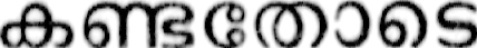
കണ്ടതോടെ
